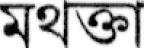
মথক্তা
